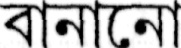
বানানো
